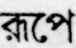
রূপে
